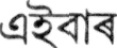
এইবাৰ
